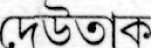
দেউতাক
